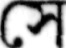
সে
